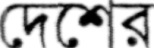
দেশের
